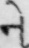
ને
